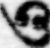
ও
